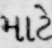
માટે
